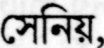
সেনিয়,
